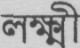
লক্ষ্মী
